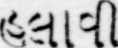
હલાવી
